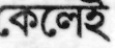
কেলেই
